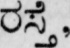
ರಸ್ತೆ,
